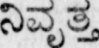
ನಿವೃತ್ತ
